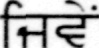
ਜਿਵੇਂ
